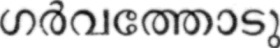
ഗര്‍വത്തോടു
